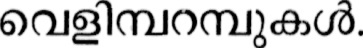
വെളിമ്പറമ്പുകള്‍.
